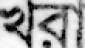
খরা
